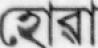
হোৱা
